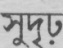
সুদৃঢ়
